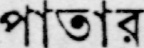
পাতার
